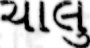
ચાલુ
